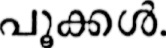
പൂക്കള്‍.
